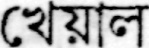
খেয়াল
